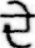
ਦੇ
